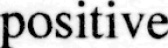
positive
